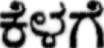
ಕೆಳಗೆ
